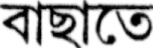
বাছাতে
